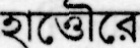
হাত্তৌরে
